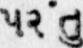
પરંતુ
